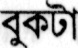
বুকটা
